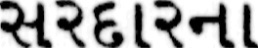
સરદારના
